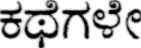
ಕಥೆಗಳೇ
